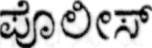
ಪೊಲೀಸ್
